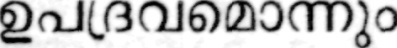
ഉപദ്രവമൊന്നും
